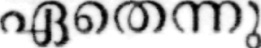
ഏതെന്നു
